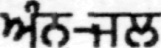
ਅੰਨ-ਜਲ
